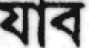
যাব
